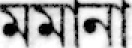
মমানা
